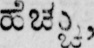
ಹೆಚ್ಚು,
